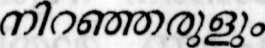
നിറഞ്ഞരുളും
